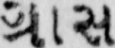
ગ્રાસ
